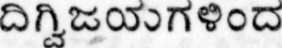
ದಿಗ್ವಿಜಯಗಳಿಂದ
